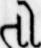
તો
